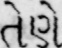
તેણે
